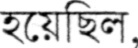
হয়েছিল,
